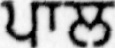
ਪਾਲ
